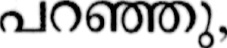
പറഞ്ഞു,
